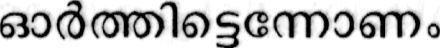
ഓര്‍ത്തിട്ടെന്നോണം
